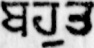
ਬਹੁਤ
